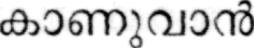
കാണുവാന്‍
